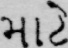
માટે
